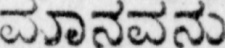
ಮಾನವನು
